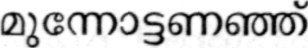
മുന്നോട്ടണഞ്ഞ്
